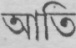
আতি
